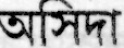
অসিদা
